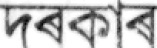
দৰকাৰ
